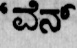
‘ವೆನ್
